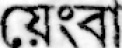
য়েংবা
